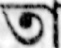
তা
